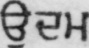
ਉਦਮ
